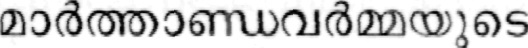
മാര്‍ത്താണ്ഡവര്‍മ്മയുടെ
